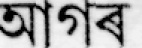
আগৰ
